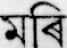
মৰি
